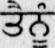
ਤੈਨੂੰ
